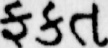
ફક્ત
